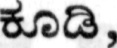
ಕೂಡಿ,
